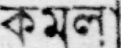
কমলা
